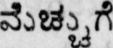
ಮೆಚ್ಚುಗೆ
